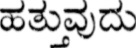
ಹತ್ತುವುದು
